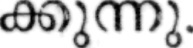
ക്കുന്നു.
